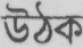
উঠক
